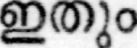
ഇതും
